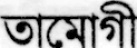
তামোগী
